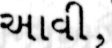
આવી,
